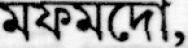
মফমদো,
